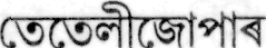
তেতেলীজোপাৰ
